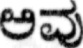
ಅವು
